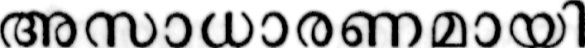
അസാധാരണമായി
